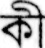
কী
